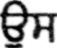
ਉਸ
